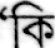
'কি
